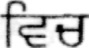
ਵਿਚ
